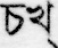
চখ্
